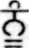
ਨੂੰ
